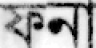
ফনা
